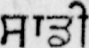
ਸਾਡੀ
